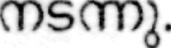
നടന്നു.
